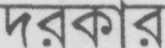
দরকার
